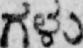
ಗಳು
